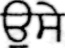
ਉਸੇ
